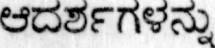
ಆದರ್ಶಗಳನ್ನು
